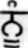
ਨੂੰ
